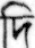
দি
